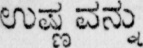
ಉಷ್ಣವನ್ನು
